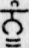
ਨੂੰ
